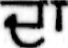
ਦਾ
